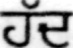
ਹੱਦ
